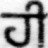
ਹੀ
